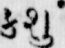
કશું
